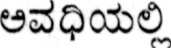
ಅವಧಿಯಲ್ಲಿ
